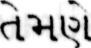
તેમણે
